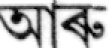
আৰু
